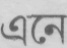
এনে
